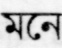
মনে
